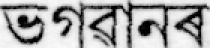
ভগৱানৰ
